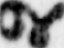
જ
